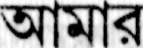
আমার
